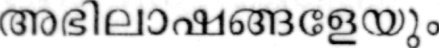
അഭിലാഷങ്ങളേയും
